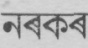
নৰকৰ
